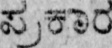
ಪ್ರಕಾರ
